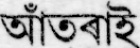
আঁতৰাই
